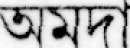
অমদা
